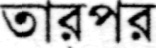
তারপর
